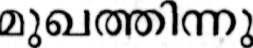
മുഖത്തിന്നു
